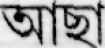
আছা
